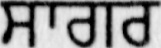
ਸਾਗਰ
